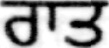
ਰਾਤ
